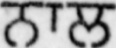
ਨਾਲ
